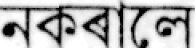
নকৰালে
